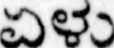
ಏಳು
